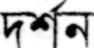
দর্শন
